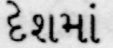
દેશમાં
